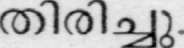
തിരിച്ചു.
